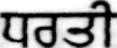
ਧਰਤੀ
